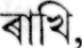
ৰাখি,
